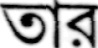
তার
